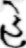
હે
